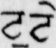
ਟੁਟੇ
